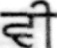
ਵੀ
